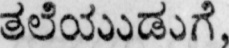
ತಲೆಯುಡುಗೆ,
